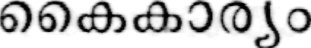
കൈകാര്യം
